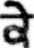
ਕੇ
